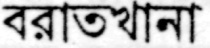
বরাতখানা
